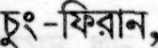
চুং-ফিরান,
